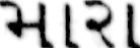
મારા
